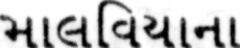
માલવિયાના
